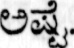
ಅಷ್ಟೆ.
